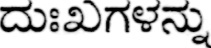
ದುಃಖಗಳನ್ನು
